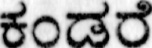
ಕಂಡರೆ
